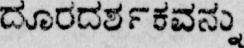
ದೂರದರ್ಶಕವನ್ನು
